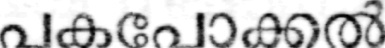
പകപോക്കല്‍
